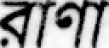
রাণা
